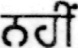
ਨਹੀਂ
